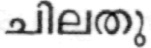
ചിലതു
